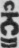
ਨੂੰ
